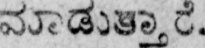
ಮಾಡುತ್ತಾರೆ.
